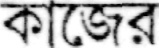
কাজের
